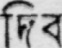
দিব
